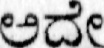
ಅದೇ
